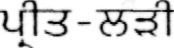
ਪ੍ਰੀਤ-ਲੜੀ
